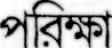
পরিক্ষা
